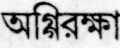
অগ্গিরক্ষা
